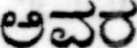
ಅವರ
